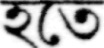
হতে
